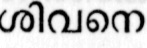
ശിവനെ
